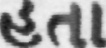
હતા
